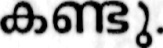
കണ്ടു.
